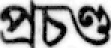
প্রচণ্ড
